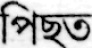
পিছত
